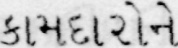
કામદારોને
